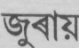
জুৰায়
